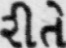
રીતે
